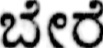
ಬೇರೆ
